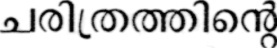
ചരിത്രത്തിന്റെ
